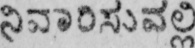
ನಿವಾರಿಸುವಲ್ಲಿ
